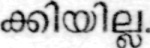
ക്കിയില്ല.
